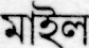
মাইল
